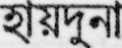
হায়দুনা
